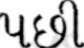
પછી
